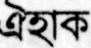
ঐহাক
